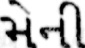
મેની
